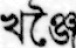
খঞ্জৈ
